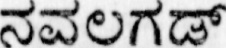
ನವಲಗಡ್
